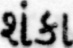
શંકા
